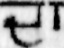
ਦਾ
